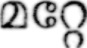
മറ്റേ
